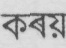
কৰয়
